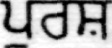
ਪੁਰਸ਼
